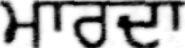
ਮਾਰਦਾ
